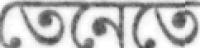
তেনেতে
